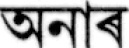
অনাৰ
